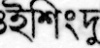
ওইশিংদু
